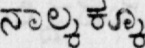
ನಾಲ್ಕಕ್ಕೂ
